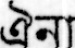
ঐনা
